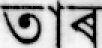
তাৰ
